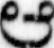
ಆ
